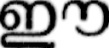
ഈ
